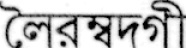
লৈরম্বদগী
